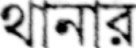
থানার
